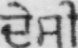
ਦੇਸੀ
